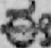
ಈ
